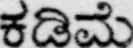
ಕಡಿಮೆ
